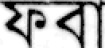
ফবা
